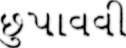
છુપાવવી
